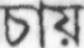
চায়
